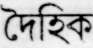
দৈহিক
